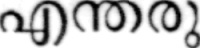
എന്തരു
